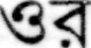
ওর
